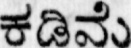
ಕಡಿಮೆ
